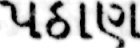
પઠાણ
